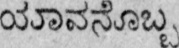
ಯಾವನೊಬ್ಬ
